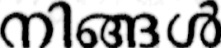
നിങ്ങള്‍
